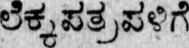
ಲೆಕ್ಕಪತ್ರಪಳಿಗೆ
